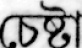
চেষ্টা
